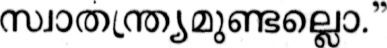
സ്വാതന്ത്ര്യമുണ്ടല്ലൊ."
